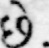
છે.
